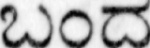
ಬಂದ
